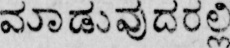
ಮಾಡುವುದರಲ್ಲಿ
